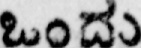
ಒಂದು
